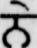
ਨੇ
